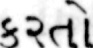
કરતો
